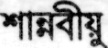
শান্নবীয়ু
